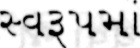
સ્વરૂપમાં
